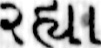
રહ્યા
